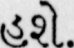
હશે.
